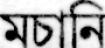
মচানি
